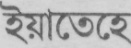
ইয়াতেহে
